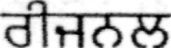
ਰੀਜਨਲ
